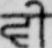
ਵੀ
